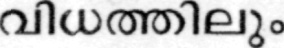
വിധത്തിലും
